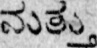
ಮತ್ತು
